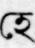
হে
